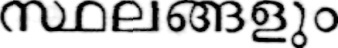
സ്ഥലങ്ങളും
